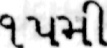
૧૫મી
